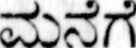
ಮನೆಗೆ
